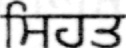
ਸਿਹਤ
